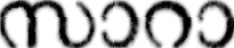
സാറാ
